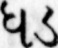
ધડ
